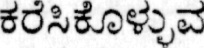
ಕರೆಸಿಕೊಳ್ಳುವ
